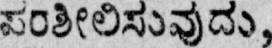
ಪರಶೀಲಿಸುವುದು,
